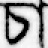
চা
